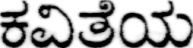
ಕವಿತೆಯ
